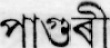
পাগুৰী
